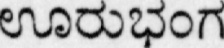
ಊರುಭಂಗ
